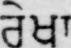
ਰੇਖਾ
